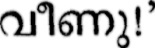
വീണു!’
